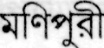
মণিপুরী
